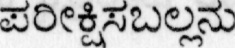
ಪರೀಕ್ಷಿಸಬಲ್ಲನು
